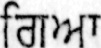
ਗਿਆ
